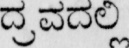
ದ್ರವದಲ್ಲಿ
